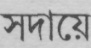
সদায়ে
